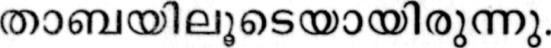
താബയിലൂടെയായിരുന്നു.
